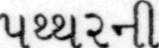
પથ્થરની
